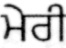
ਮੇਰੀ
